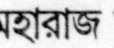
মহারাজ
